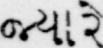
જ્યારે
